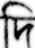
দি
